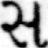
સ
